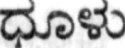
ಧೂಳು
